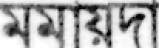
মমায়দা
